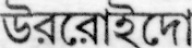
উররোইদো
